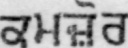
ਕਮਜ਼ੋਰ
